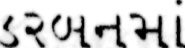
ડરખનમાં
